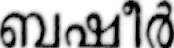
ബഷീര്‍
